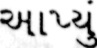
આપ્યું
